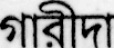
গারীদা
